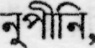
নুপীনি,
